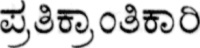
ಪ್ರತಿಕ್ರಾಂತಿಕಾರಿ
